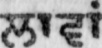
ਲਾਵਾਂ
